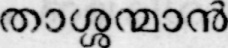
താശ്ശന്മാന്‍
